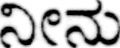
ನೀನು
